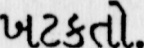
ખટકતો.
